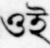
ওই
